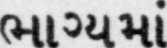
ભાગ્યમાં
